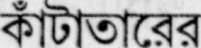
কাঁটাতারের
